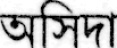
অসিদা
